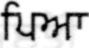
ਪਿਆ
